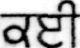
ਕਈ
